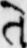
તે
